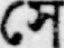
সে
